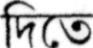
দিতে
